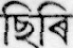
ছিৰি
